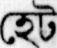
হেট
